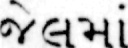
જેલમાં
